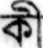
কী
